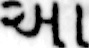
આ
